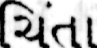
ચિંતા
